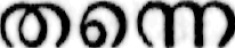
തന്നെ
